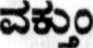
ವಕ್ತುಂ
